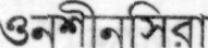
ওনশীনসিরা
